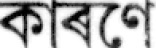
কাৰণে
